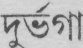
দুৰ্ভগা
